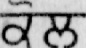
ਕੋਲ
